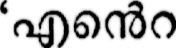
‘എന്റെ
